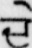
ਦੇ
